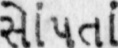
સોંપતાં
